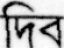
দিব
